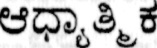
ಆಧ್ಯಾತ್ಮಿಕ
